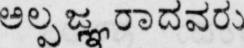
ಅಲ್ಪಜ್ಞರಾದವರು
